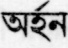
অর্হন
